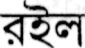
রইল
